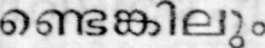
ണ്ടെങ്കിലും
